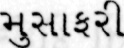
મુસાફરી
